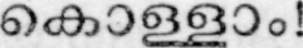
കൊള്ളാം!
